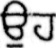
ਉਹ
